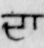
ਦਾ
